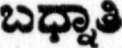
ಬಧ್ನಾತಿ
